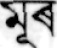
মূৰ
